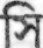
সি
